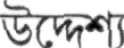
উদ্দেশ্য
